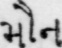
મૌન
